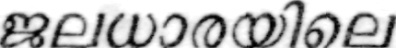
ജലധാരയിലെ
